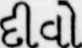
દીવો
